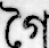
গৈ
